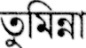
তুমিন্না
